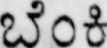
ಬೆಂಕಿ
